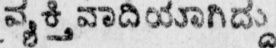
ವ್ಯಕ್ತಿವಾದಿಯಾಗಿದ್ದು
